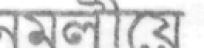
নমলীয়ে
